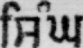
ਸਿੰਘ
